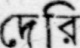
দেরি
